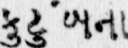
કુટુંબના
